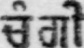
ਚੰਗੀ
